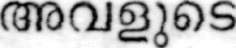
അവളുടെ
